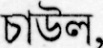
চাউল,
